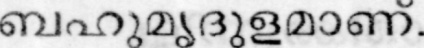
ബഹുമൃദുളമാണ്.
